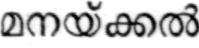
മനയ്ക്കല്‍
